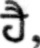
ਹੈ,
